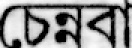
চেন্নবা
